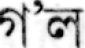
গ'ল
